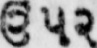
ઉપર
